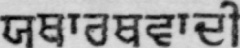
ਯਥਾਰਥਵਾਦੀ
